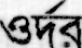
ওর্দর
